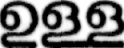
ഉള്ള
